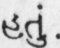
હતું.
